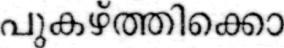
പുകഴ്ത്തിക്കൊ
